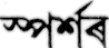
স্পর্শৰ
